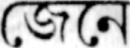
জেনে
